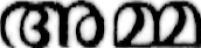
അമ്മ
